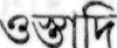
ওস্তাদি
